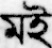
মই
